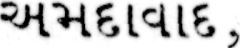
અમદાવાદ,
